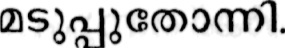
മടുപ്പുതോന്നി.
